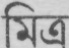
মিত্ৰ
